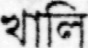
খালি
